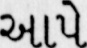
આપે
